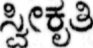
ಸ್ವೀಕೃತಿ
